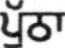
ਪੁੱਠਾ
